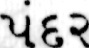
પંદર
